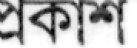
প্রকাশ
